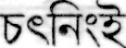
চৎনিংই
